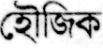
হৌজিক
